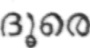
ദൂരെ
